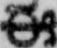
ಈ
